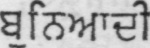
ਬੁਨਿਆਦੀ
